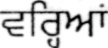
ਵਰ੍ਹਿਆਂ
